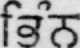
ਭਿੰਨ
